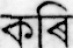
কৰি
